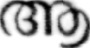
ആ
